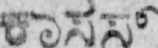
ಕಾಸಸ್
